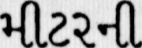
મીટરની
